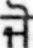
ਜੋ
